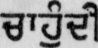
ਚਾਹੁੰਦੀ
